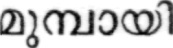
മുമ്പായി
